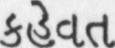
કહેવત
